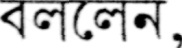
বললেন,
